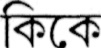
কিকে
